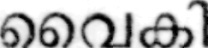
വൈകി
